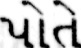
પોતે
